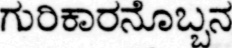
ಗುರಿಕಾರನೊಬ್ಬನ
